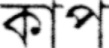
কাপ
